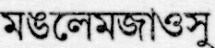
মঙলেমজাওসু
